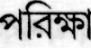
পরিক্ষা
